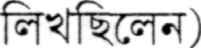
লিখছিলেন)
